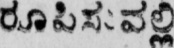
ರೂಪಿಸುವಲ್ಲಿ
